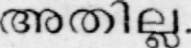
അതില്ല.
